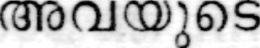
അവയുടെ
